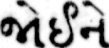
જોઈને
